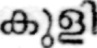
കുളി
